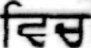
ਵਿਚ
